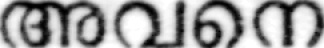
അവനെ
